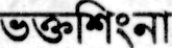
ভক্তশিংনা
